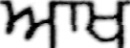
ਆਖ
